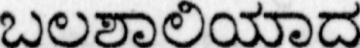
ಬಲಶಾಲಿಯಾದ
